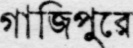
গাজিপুরে
